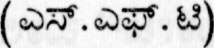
(ಎಸ್.ಎಫ್.ಟಿ)
